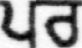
ਪਰ
